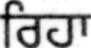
ਰਿਹਾ
